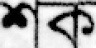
শক
